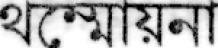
থম্মোয়না
